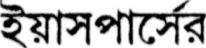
ইয়াসপার্সের
